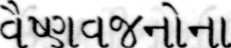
વૈષ્ણવજનોના
